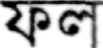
ফল
